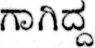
ಗಾಗಿದ್ದ
